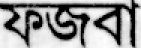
ফজবা
